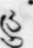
હું
